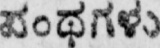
ಪಂಥಗಳು
